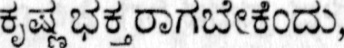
ಕೃಷ್ಣಭಕ್ತರಾಗಬೇಕೆಂದು,
